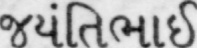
જયંતિભાઈ
